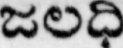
ಜಲಧಿ
